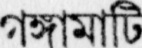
গঙ্গামাটি
